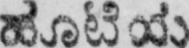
ಹೂಟೆಯ
